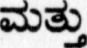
ಮತ್ತು
